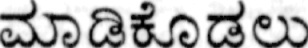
ಮಾಡಿಕೊಡಲು
